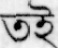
তই
